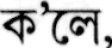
ক'লে,
